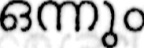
ഒന്നും
